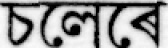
চলেৰে
